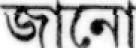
জানো
